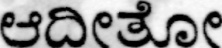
ಆದೀತೋ
